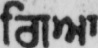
ਗਿਆ
